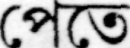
পেতে
